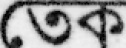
তেক
